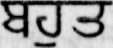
ਬਹੁਤ
